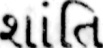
શાંતિ
